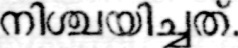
നിശ്ചയിച്ചത്.
